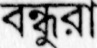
বন্ধুরা
